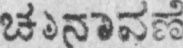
ಚುನಾವಣೆ
